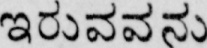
ಇರುವವನು
